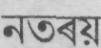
নতৰয়
